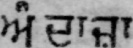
ਅੰਦਾਜ਼ਾ
